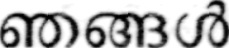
ഞങ്ങള്‍
